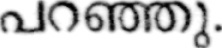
പറഞ്ഞു.
